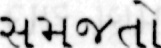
સમજતો
